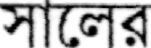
সালের
